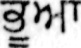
ਭੂਆ
